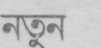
নতুন
